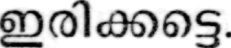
ഇരിക്കട്ടെ.
